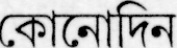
কোনোদিন
